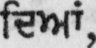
ਦਿਆਂ,
